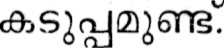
കടുപ്പമുണ്ട്.
